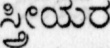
ಸ್ತ್ರೀಯರ
